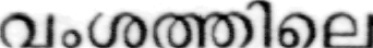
വംശത്തിലെ
